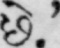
છે.'
